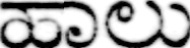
ಹಾಲು
